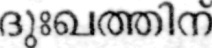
ദുഃഖത്തിന്
